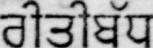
ਰੀਤੀਬੱਧ
